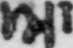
ਆ
